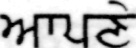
ਆਪਣੇ
